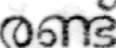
രണ്ട്
